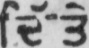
ਦਿੱਤੇ
